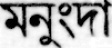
মনুংদা
